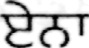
ਏਨਾ
